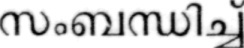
സംബന്ധിച്ച്
